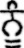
ਨੂੰ
